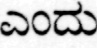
ಎಂದು
